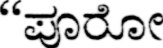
"ಪೂರೋ
